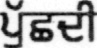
ਪੁੱਛਦੀ
